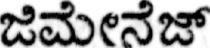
ಜಿಮೇನೆಜ್
